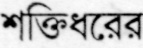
শক্তিধরের
